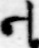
ન
